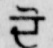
ਦੋ
